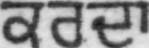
ਕਰਦਾ
